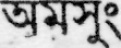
অমসুং
